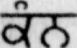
ਕੰਨ
